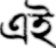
এই
